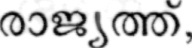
രാജ്യത്ത്,
